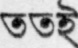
ততই
